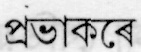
প্রভাকৰে
